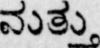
ಮತ್ತು
